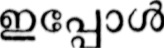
ഇപ്പോള്‍
